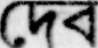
দেব
